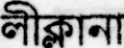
লীক্লানা
